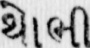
થોભી
